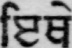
ਇਥੇ
